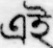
এই
